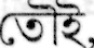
তৌই,
